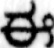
ಈ
